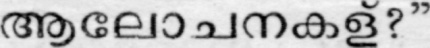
ആലോചനകള്?"
